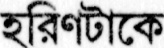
হরিণটাকে
